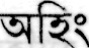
অহীং
